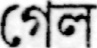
গেল
